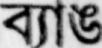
ব্যাঙ
